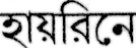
হায়রিনে
